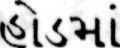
હોડમાં
